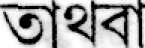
তাথবা
